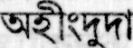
অহীংদুদা
